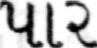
પાર
